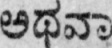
ಅಥವಾ
